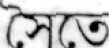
সৈতে
